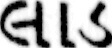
લાડ
